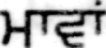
ਮਾਵਾਂ
